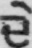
ਦੇ
